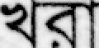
খরা
